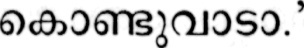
കൊണ്ടുവാടാ.'
